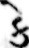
કે
